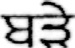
ਬੜੇ
